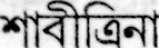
শাবীত্রিনা
